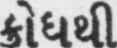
ક્રોધથી
